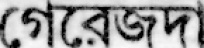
গেরেজদা
